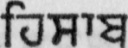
ਹਿਸਾਬ
